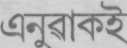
এনুৱাকই
